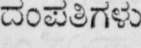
ದಂಪತಿಗಳು
